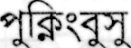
পুক্নিংবুসু
